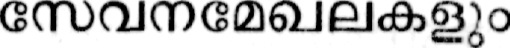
സേവനമേഖലകളും
